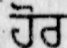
ਹੋਰ
